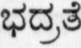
ಭದ್ರತೆ
